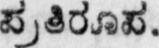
ಪ್ರತಿರೂಪ.
